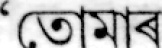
'তোমাৰ
